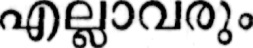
എല്ലാവരും
